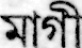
মাগী
